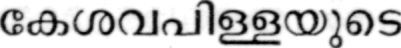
കേശവപിള്ളയുടെ
